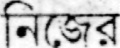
নিজের
